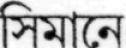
সিমানে
